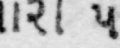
તરવા
